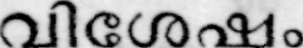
വിശേഷം
